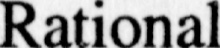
Rational
